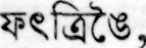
ফৎত্রিঙৈ,
